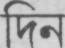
দিন
